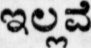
ಇಲ್ಲವೆ
